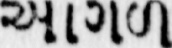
આગળ
